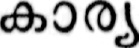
കാര്യ
